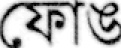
ফোঙ
